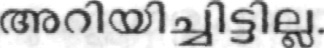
അറിയിച്ചിട്ടില്ല.
